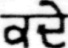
ਕਦੇ
